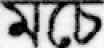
মচে
